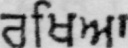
ਰਖਿਆ
